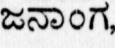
ಜನಾಂಗ,
